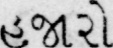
હજારો
